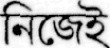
নিজেই
